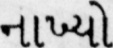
નાખ્યો
